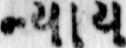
ન્યાય
